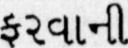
ફરવાની
